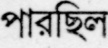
পারছিল
